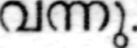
വന്നു.
